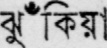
ঝুঁকিয়া
